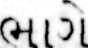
ભાગે
